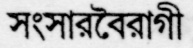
সংসারবৈরাগী
